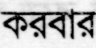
করবার
